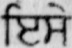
ਇਸੇ
